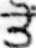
ਤੋਂ
